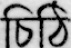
চিঠি
